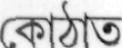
কোঠাত
